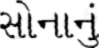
સોનાનું
